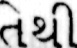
તેથી
